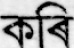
কৰি
